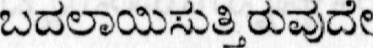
ಬದಲಾಯಿಸುತ್ತಿರುವುದೇ
